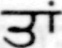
ਤਾਂ
